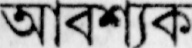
আবশ্যক
